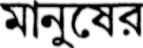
মানুষের
